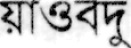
য়াওবদু
